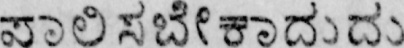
ಪಾಲಿಸಬೇಕಾದುದು
